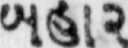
બહાર
